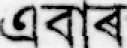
এবাৰ
